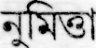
নুমিত্তা
